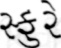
સ્ફુરે
